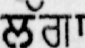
ਲੱਗਾ
